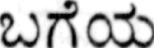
ಬಗೆಯ
